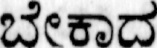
ಬೇಕಾದ
